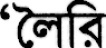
‘লৈরি
